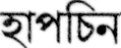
হাপচিন
